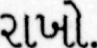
રાખો.
